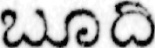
ಬೂದಿ
